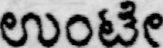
ಉಂಟೇ
